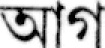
আগ
